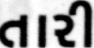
તારી
